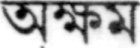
অক্ষম
